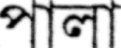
পালা
